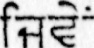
ਜਿਵੇਂ
